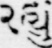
રહ્યું
